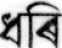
ধৰি
